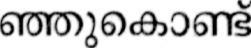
ഞ്ഞുകൊണ്ട്
